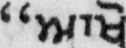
''ਆਖੋ
